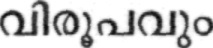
വിരൂപവും
